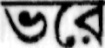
ভরে
